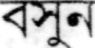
বসুন
